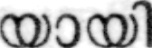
യായി
